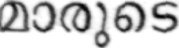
മാരുടെ
